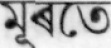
মূৰতে
